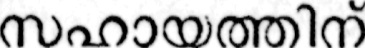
സഹായത്തിന്
